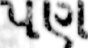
પણ
